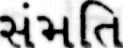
સંમતિ
